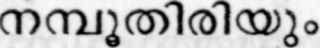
നമ്പൂതിരിയും
